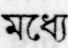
মধ্যে
